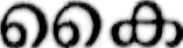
കൈ
